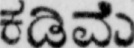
ಕಡಿಮೆ
